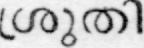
ശ്രുതി
